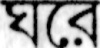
ঘরে
